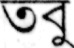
তবু
